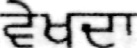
ਵੇਖਦਾ
